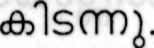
കിടന്നു.
